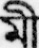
মী
